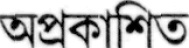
অপ্রকাশিত
